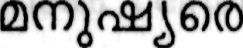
മനുഷ്യരെ
